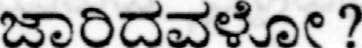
ಜಾರಿದವಳೋ?
